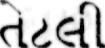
તેટલી
